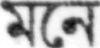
মনে
